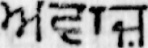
ਅਵਾਜ਼
